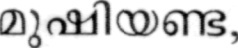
മുഷിയണ്ട,
